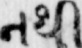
નથી
